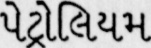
પેટ્રોલિયમ
